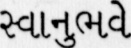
સ્વાનુભવે
